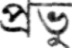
প্রভু
